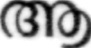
ആ
